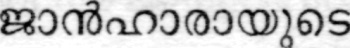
ജാന്‍ഹാരായുടെ
